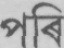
পৰি
